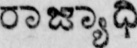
ರಾಜ್ಯಾಧಿ
